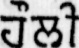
ਹੌਲੀ
